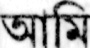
আমি
